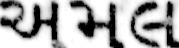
અમલ
